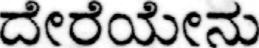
ದೇರೆಯೇನು
